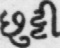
છુટ્ટી
